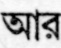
আর
